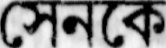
সেনকে
